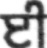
ਈ
